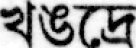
খঙদ্রে
